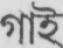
গাই
